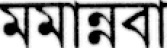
মমান্নবা
